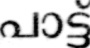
പാട്ട്
